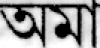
অমা
